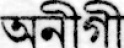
অনীগী
